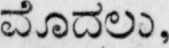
ಮೊದಲು,
